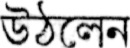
উঠলেন
